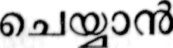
ചെയ്യാന്‍
